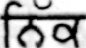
ਨਿੱਕ
